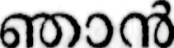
ഞാന്‍
